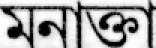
মনাক্তা
